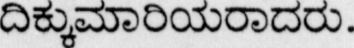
ದಿಕ್ಕುಮಾರಿಯರಾದರು.
